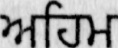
ਅਹਿਮ
